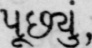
પૂછ્યું,
